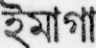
ইমাগা
